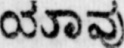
ಯಾವು
